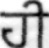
ਹੀ
